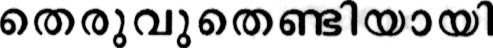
തെരുവുതെണ്ടിയായി
